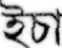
ইচা
